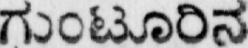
ಗುಂಟೂರಿನ
